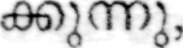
ക്കുന്നു,
